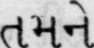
તમને
